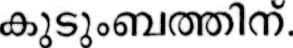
കുടുംബത്തിന്.
